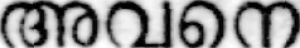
അവനെ
